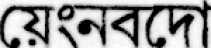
য়েংনবদো
